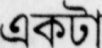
একটা
